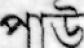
পাউ
